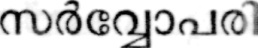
സര്‍വ്വോപരി
